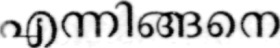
എന്നിങ്ങനെ
